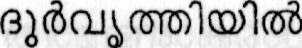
ദുര്‍വൃത്തിയില്‍
